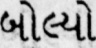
બોલ્યો
